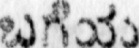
ಬಗೆಯ
